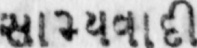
સામ્યવાદી
